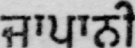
ਜਾਪਾਨੀ
